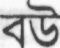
বউ
